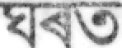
ঘৰত
